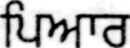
ਪਿਆਰ
